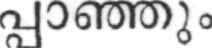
പ്പാഞ്ഞും
